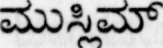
ಮುಸ್ಲಿಮ್
